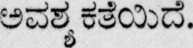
ಅವಶ್ಯಕತೆಯಿದೆ.
